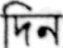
দিন
